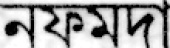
নফমদা
